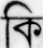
কি
